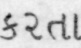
કરતા
